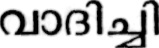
വാദിച്ചി
